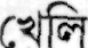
খেলি
